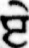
ਏ
